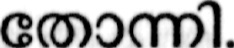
തോന്നി.
